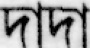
দাদা
